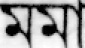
মমা
